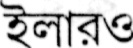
ইলারও
